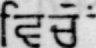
ਵਿਚੋਂ
